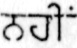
ਨਹੀਂ
